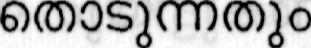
തൊടുന്നതും
